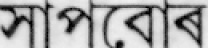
সাপবোৰ
